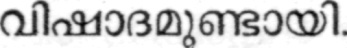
വിഷാദമുണ്ടായി.
